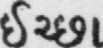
ઇચ્છા
